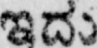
ಇದು
